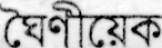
ঘৈণীয়েক
